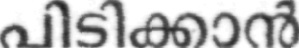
പിടിക്കാന്‍
